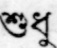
শুধু
